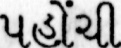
પહોંચી
